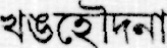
খঙহৌদনা
